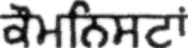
ਕੌਮਨਿਸਟਾਂ
